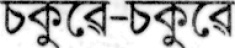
চকুৱে-চকুৱে
